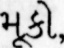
મૂકો,
